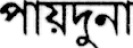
পায়দুনা
